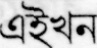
এইখন
